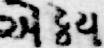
એકેય
